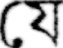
যে
